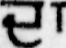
ਦਾ
